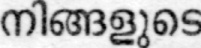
നിങ്ങളുടെ
